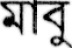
মাবু
